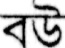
বউ
